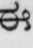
ಈ
